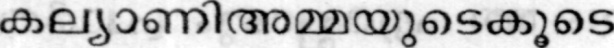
കല്യാണിഅമ്മയുടെകൂടെ
